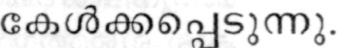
കേള്‍ക്കപ്പെടുന്നു.
